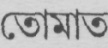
তোমাত
